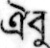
ঐবু
